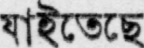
যাইতেছে
